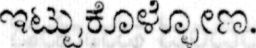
ಇಟ್ಟುಕೊಳ್ಳೋಣ.
